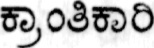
ಕ್ರಾಂತಿಕಾರಿ
